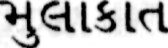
મુલાકાત
